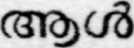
ആള്‍
